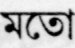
মতো
